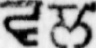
ਵਲ
